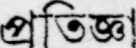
প্রতিজ্ঞা
